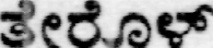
ತೇರೊಳ್
